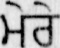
ਮੇਰੇ
